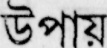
উপায়
